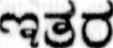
ಇತರ
